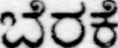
ಬೆರಕೆ
